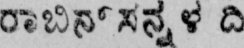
ರಾಬಿನ್‌ಸನ್ನ‌ಳದಿ
